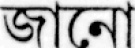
জানো
